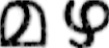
മഴ
